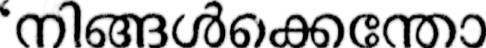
‘നിങ്ങള്‍ക്കെന്തോ
